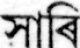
সাৰি
